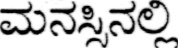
ಮನಸ್ಸಿನಲ್ಲಿ
